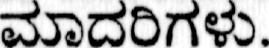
ಮಾದರಿಗಳು.
